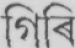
গিৰি
